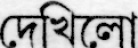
দেখিলো
